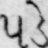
પડે
